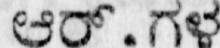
ಆರ್.ಗಳ
